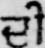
ਦੀ
